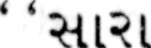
"સારા
